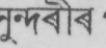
সুন্দৰীৰ
